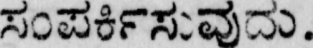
ಸಂಪರ್ಕಿಸುವುದು.
